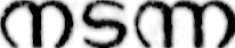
നടന്ന
